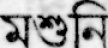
মশুনি
